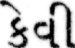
કેવી
